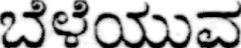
ಬೆಳೆಯುವ
